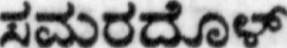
ಸಮರದೊಳ್
